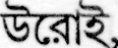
উরোই,
